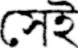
সেই
